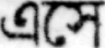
এসে
